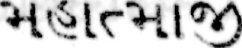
મહાત્માજી
